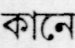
কানে
